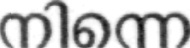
നിന്നെ
